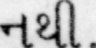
નથી.
